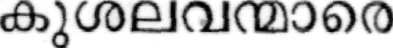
കുശലവന്മാരെ
